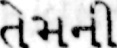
તેમની
